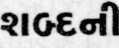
શબ્દની
